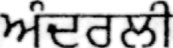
ਅੰਦਰਲੀ
